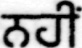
ਨਹੀਂ
